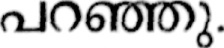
പറഞ്ഞു.
